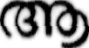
ആ
